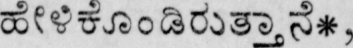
ಹೇಳಿಕೊಂಡಿರುತ್ತಾನೆ*,
